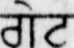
ਗੇਟ
